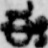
ಈ
